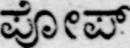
ಪೋಪ್
